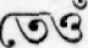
তেওঁ
